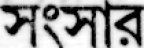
সংসার
